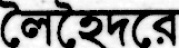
লৈহৈদরে
